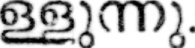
ള്ളുന്നു.
